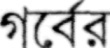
গর্বের
